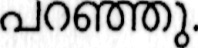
പറഞ്ഞു.
